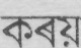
কৰয়
